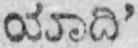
ಯಾದಿ’
